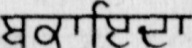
ਬਕਾਇਦਾ
